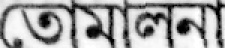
তোমালনা
